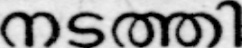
നടത്തി
